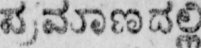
ಪ್ರಮಾಣದಲ್ಲಿ
